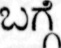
ಬಗ್ಗೆ
